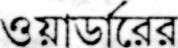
ওয়ার্ডারের
